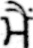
ਮੈਂ
